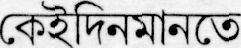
কেইদিনমানতে
